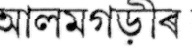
আলমগড়ীৰ
